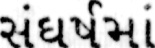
સંઘર્ષમાં
